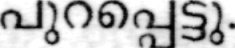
പുറപ്പെട്ടു.
